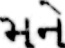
મને
